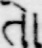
તો
